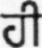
ਹੀ
